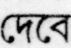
দেবে
